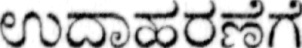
ಉದಾಹರಣೆಗೆ
